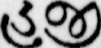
હજી
